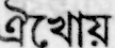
ঐখোয়
